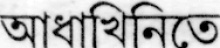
আধাখিনিতে
